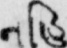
નહિ
